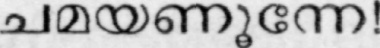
ചമയണൂന്നേ!
